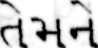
તેમને
